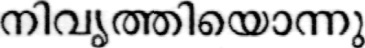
നിവൃത്തിയൊന്നു
